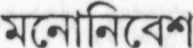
মনোনিবেশ
